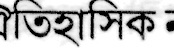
ঐতিহাসিক
